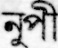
নুপী
